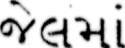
જેલમાં
